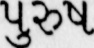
પુરુષ
